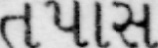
તપાસ
